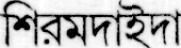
শিরমদাইদা
